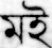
মই
